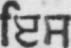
ਇਸ
